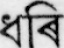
ধৰি
